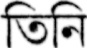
তিনি
